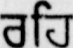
ਰਹਿ
